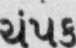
ચંપક
